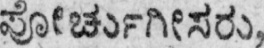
ಪೋರ್ಚುಗೀಸರು,
